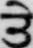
ਤੇ
